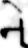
ને
